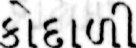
કોદાળી
